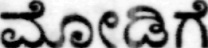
ಮೋಡಿಗೆ
